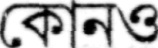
কোনও
